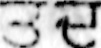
ਤਦ
